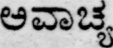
ಅವಾಚ್ಯ
